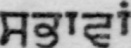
ਸਭਾਵਾਂ
